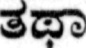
ತಥಾ
